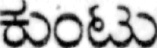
ಕುಂಟು
